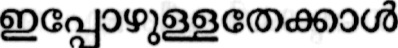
ഇപ്പോഴുള്ളതേക്കാള്‍
